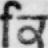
ਕਿ
